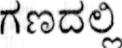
ಗಣದಲ್ಲಿ
